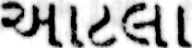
આટલા
